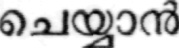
ചെയ്യാന്‍
